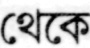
থেকে
